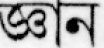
জ্ঞান
